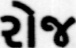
રોજ
